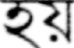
হয়
